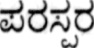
ಪರಸ್ಪರ
